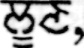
ਲੂਣ,
